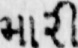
મારી
